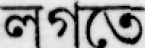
লগতে
